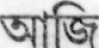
আজি
